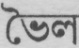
ভৈল
